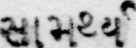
સામર્થ્ય
